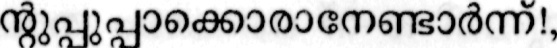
ന്റുപ്പുപ്പാക്കൊരാനേണ്ടാര്‍ന്ന്!,
